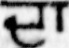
ਦਾ
